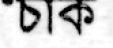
“চাক
